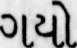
ગયો
